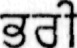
ਭਰੀ
